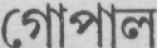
গোপাল
